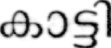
കാട്ടി
